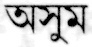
অসুম
